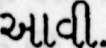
આવી.
